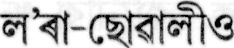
ল'ৰা-ছোৱালীও
